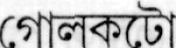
গোলকটো
